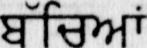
ਬੱਚਿਆਂ
